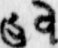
હવે
